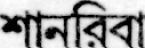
শানরিবা
